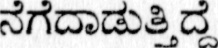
ನೆಗೆದಾಡುತ್ತಿದ್ದೆ
